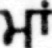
ਮਾਂ
